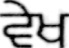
ਵੇਖ
